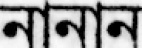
নানান
